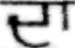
ਦਾ
